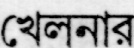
খেলনার
